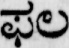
ಫಲ
